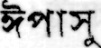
ঈপীসু
